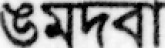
ঙমদবা
